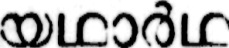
യഥാര്‍ഥ
